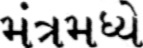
મંત્રમધ્યે
